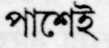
পাশেই
